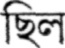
ছিল
